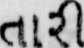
તારી
